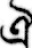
ঐ
